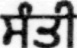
ਸੰਤੀ
